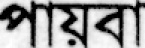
পায়বা
